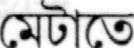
মেটাতে
